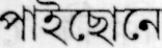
পাইছোনে
